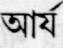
আর্য
